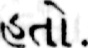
હતો.
